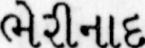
ભેરીનાદ
